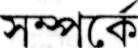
সম্পর্কে
